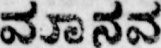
ಮಾನವ
